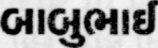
બાબુભાઈ
